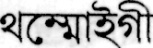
থম্মোইগী
